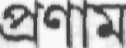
প্রণাম
